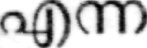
എന്ന
